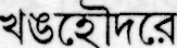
খঙহৌদরে
